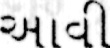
આવી
